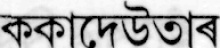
ককাদেউতাৰ
